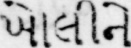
ખોલીને
